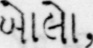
બોલો,
